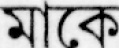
মাকে
